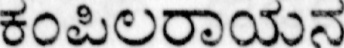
ಕಂಪಿಲರಾಯನ
